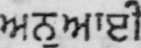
ਅਨੁਆਈ
